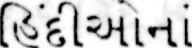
હિંદીઓનાં
